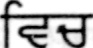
ਵਿਚ
